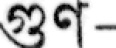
গুণ-
